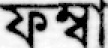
ফম্বা
